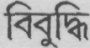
বিবুদ্ধি
